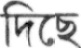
দিছে
